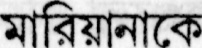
মারিয়ানাকে
